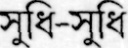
সুধি-সুধি
